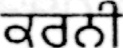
ਕਰਨੀ
